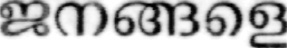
ജനങ്ങളെ
